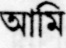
আমি
